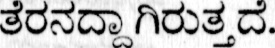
ತೆರನದ್ದಾಗಿರುತ್ತದೆ.
